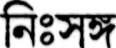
নিঃসঙ্গ
